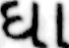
ઘા
